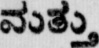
ಮತ್ತು
